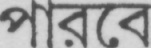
পারবে
